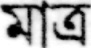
মাত্র
